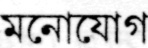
মনোযোগ
